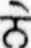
ਨੇ
